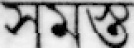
সমস্ত
